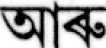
আৰু
